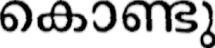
കൊണ്ടു
